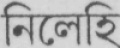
নিলেহি
